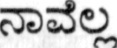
ನಾವೆಲ್ಲ
